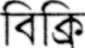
বিক্রি
